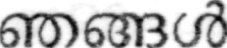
ഞങ്ങള്‍
